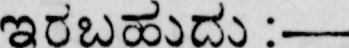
ಇರಬಹುದು:-
